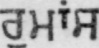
ਰੁਮਾਂਸ
